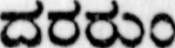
ದರರುಂ
